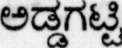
ಅಡ್ಡಗಟ್ಟಿ
